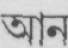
আন
